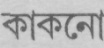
কাকনো
